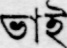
ভাই
